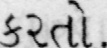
કરતો.
